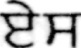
ਏਸ
